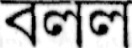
বলল
